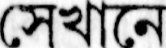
সেখানে
